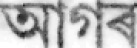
আগৰ
